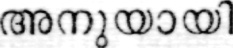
അനുയായി
